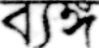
ব্যঙ্গ
